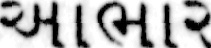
આભાર
